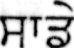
ਸਾਡੇ
